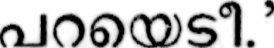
പറയെടീ.'
